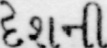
દેશની
